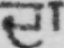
ਦਾ
